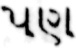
પણ
